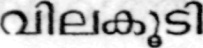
വിലകൂടി
